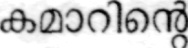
കമാറിന്റെ
